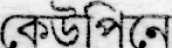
কেউপিনে
